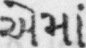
એમાં
